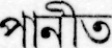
পানীত
